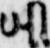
બી
